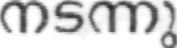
നടന്നു
